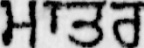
ਮਾਤਰ
